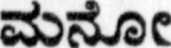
ಮನೋ
